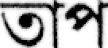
তাপ
